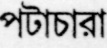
পটাচারা
